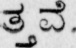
ತ್ತವೆ.
